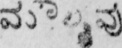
ಮೌಲ್ಯವು
